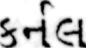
કર્નલ
